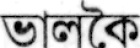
ভালকৈ
